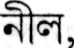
নীল,
